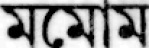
মমোম
